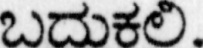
ಬದುಕಲಿ.
